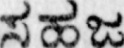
ಸಹಜ
